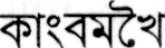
কাংবমখৈ
